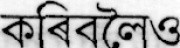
কৰিবলৈও
